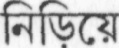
নিড়িয়ে
